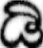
ಡಿ
